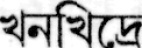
খনখিদ্রে
